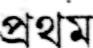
প্রথম
